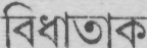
বিধাতাক
